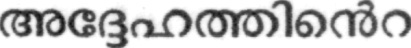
അദ്ദേഹത്തിന്റെ
